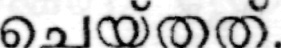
ചെയ്തത്.
